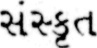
સંસ્કૃત
